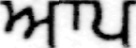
ਆਪ
